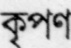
কৃপণ
